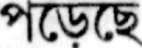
পড়েছে
